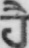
ਹੈ
